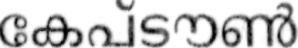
കേപ്ടൌണ്‍
